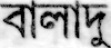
বালাদু
